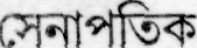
সেনাপতিক
